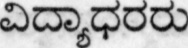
ವಿದ್ಯಾಧರರು
